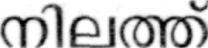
നിലത്ത്
